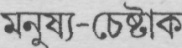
মনুষ্য-চেষ্টাক
